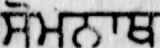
ਸੋਮਨਾਥ
